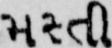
મસ્તી
